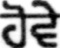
ਹੋਵੇ
